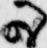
જે
